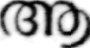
ആ
